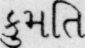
કુમતિ
